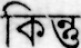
কিন্তু
